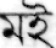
মই
